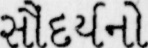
સૌંદર્યનો
